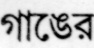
গাঙের
